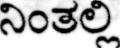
ನಿಂತಲ್ಲಿ
